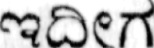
ಇದೀಗ
